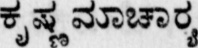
ಕೃಷ್ಣಮಾಚಾರ್ಯ
